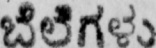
ಬೆಲೆಗಳು
